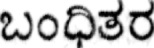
ಬಂಧಿತರ
